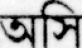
অসি
